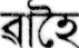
ৱাহৈ
